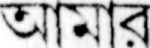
আমার
